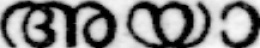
അയാ
